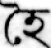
হৈ
